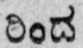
ರಿಂದ
